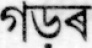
গড়ৰ
